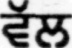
ਵੱਲ
